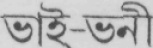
ভাই-ভনী
